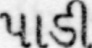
પાડી
